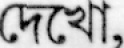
দেখো,
